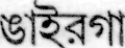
ঙাইরগা
